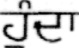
ਹੁੰਦਾ
